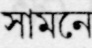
সামনে
